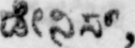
ಡೇನಿಸ್,
